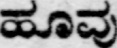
ಹೂವು
